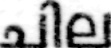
ചില
